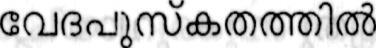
വേദപുസ്കതത്തില്‍
